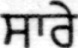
ਸਾਰੇ
